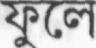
ফুলে
